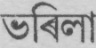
ভৰিলা
